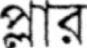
প্লার
